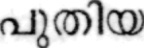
പുതിയ
